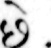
છે.
